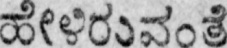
ಹೇಳಿರುವಂತೆ
